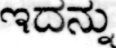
ಇದನ್ನು
